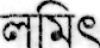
লমিৎ
